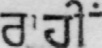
ਰਾਹੀਂ
